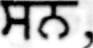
ਸਨ,
